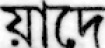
য়াদে
